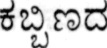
ಕಬ್ಬಿಣದ
